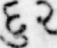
દુર
